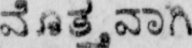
ಮೊತ್ತವಾಗಿ
